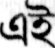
এই
